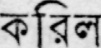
করিল
